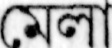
মেলা
